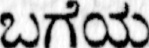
ಬಗೆಯ
